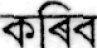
কৰিব
